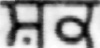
ਸ਼ਕ
